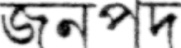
জনপদ
